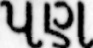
પણ
